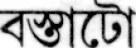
বস্তাটো
